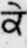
ਕੇ
